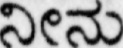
ನೀನು
